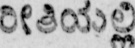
ರೀತಿಯಲ್ಲಿ
